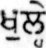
ਖੁਲ੍ਹੇ
